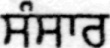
ਸੰਸਾਰ
